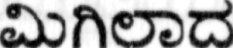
ಮಿಗಿಲಾದ
